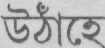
উঠাঁহে
